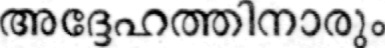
അദ്ദേഹത്തിനാരും
